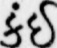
કંઈ
